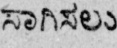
ಸಾಗಿಸಲು
